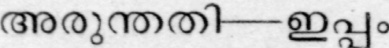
അരുന്തതി-ഇപ്പം
